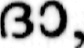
ദാ,
